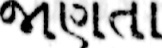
જાણતા
